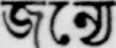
জন্যে
